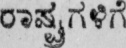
ರಾಷ್ಟ್ರಗಳಿಗೆ
